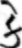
કે
